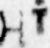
ਮਾਂ
